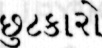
છુટકારો
